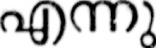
എന്നു
